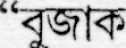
"বুজাক
